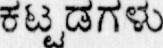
ಕಟ್ಟಡಗಳು
